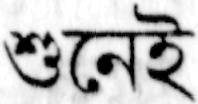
শুনেই
